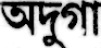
অদুগা
